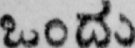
ಒಂದು
